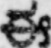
ಈ
